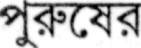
পুরুষের
